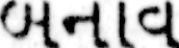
બનાવ
